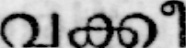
വക്കീ
